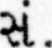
સં.
